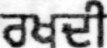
ਰਖਦੀ
